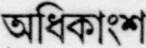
অধিকাংশ
